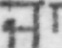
ਜਾ
